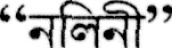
“নলিনী”
